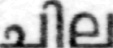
ചില
